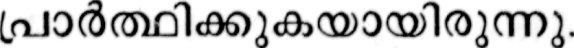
പ്രാര്‍ത്ഥിക്കുകയായിരുന്നു.
